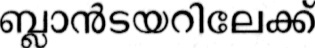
ബ്ലാന്‍ടയറിലേക്ക്
